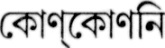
কোণ‌কোণনি
